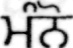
ਮੰਨੋ
